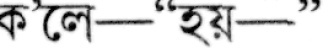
ক'লে-"হয়-"
